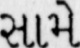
સામે
